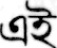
এই
